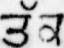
ਤੱਕ
